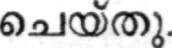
ചെയ്തു.
